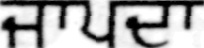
ਜਾਪਦਾ
